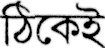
ঠিকেই
